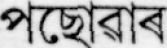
পছোৱাৰ
